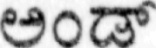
ಅಂಡ್
